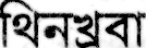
থিনখ্রবা
